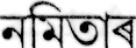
নমিতাৰ
